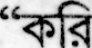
“করি
